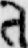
તે
